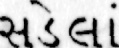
સડેલાં
